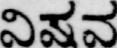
ವಿಷವ
